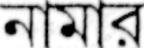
নামার
